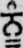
ਨੂੰ
